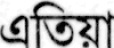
এতিয়া
